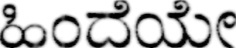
ಹಿಂದೆಯೇ
